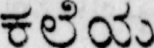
ಕಲೆಯ
